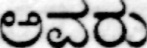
ಅವರು
